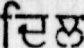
ਦਿਲ
